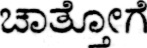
ಚಾತ್ತೋಗೆ
